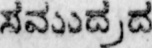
ಸಮುದ್ರದ
